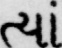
ત્યાં
